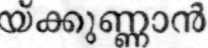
യ്ക്കുണ്ണാന്‍
